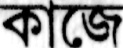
কাজে
